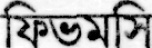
ফিভমসি
